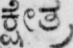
ಕ್ಷೇತ್ರ
